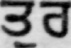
ਤੁਰ
